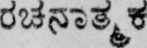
ರಚನಾತ್ಮಕ
